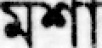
মশা
